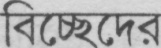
বিচ্ছেদের
